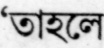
‘তাহলে
